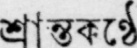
শ্রান্তকণ্ঠে
